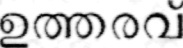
ഉത്തരവ്
